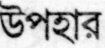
উপহার
